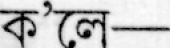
ক'লে-
